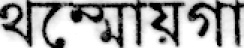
থম্মোয়গা
